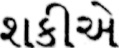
શકીએ
